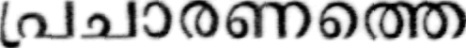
പ്രചാരണത്തെ
